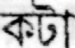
কটা
